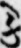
કે
